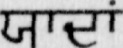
ਯਾਦਾਂ
